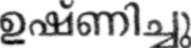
ഉഷ്ണിച്ചു
